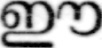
ഈ
